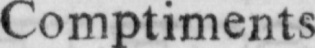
Comptiments
